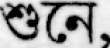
শুনে,
